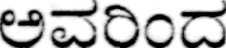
ಅವರಿಂದ
